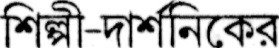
শিল্পী-দার্শনিকের
